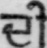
ਦੀ
